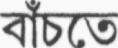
বাঁচতে
